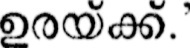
ഉരയ്ക്ക്.'
